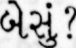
બેસું?
